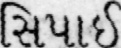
સિપાઈ
